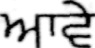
ਆਵੇ
